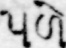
પળે
